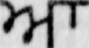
ਆ
